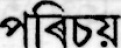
পৰিচয়
